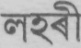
লহৰী
